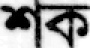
শক
